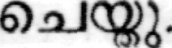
ചെയ്തു.
